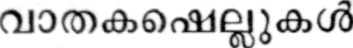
വാതകഷെല്ലുകള്‍
